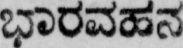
ಭಾರವಾಹನ
